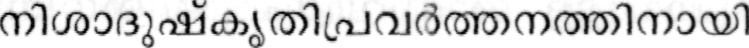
നിശാദുഷ്കൃതിപ്രവര്‍ത്തനത്തിനായി
